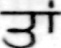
ਤਾਂ
